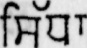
ਸਿੱਧਾ
